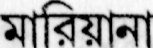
মারিয়ানা
